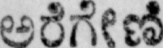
ಅರೆಗೇಣಿ
